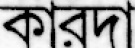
কারদা
